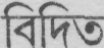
বিদিত
